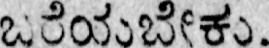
ಬರೆಯಬೇಕು.
